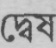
দ্বেষ
